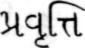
પ્રવૃત્તિ
